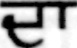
ਦਾ
